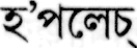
হ'পলেচ্
